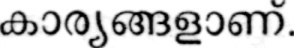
കാര്യങ്ങളാണ്.
